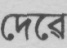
দেৱে
